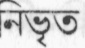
নিভৃত
